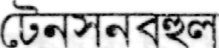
টেনসনবহুল
